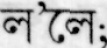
ল'লে;
